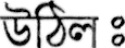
উঠিলঃ
